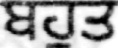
ਬਹੁਤ
